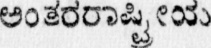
ಅಂತರರಾಷ್ಟ್ರೀಯ
